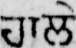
ਹਾਲੇ
